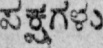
ಪಕ್ಷಗಳು
